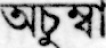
অচুম্বা
